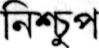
নিশ্চুপ
